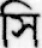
সি
